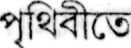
পৃথিবীতে
